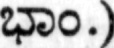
ಭಾಂ.)
